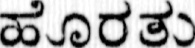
ಹೊರತು
